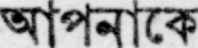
আপনাকে
